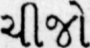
ચીજો
